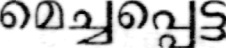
മെച്ചപ്പെട്ട
